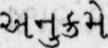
અનુક્રમે
